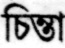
চিন্তা
